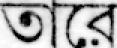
তারে
